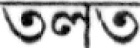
তলত
